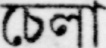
চেলা
